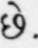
છે.
